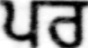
ਪਰ
